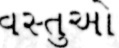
વસ્તુઓ
